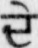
ਦੇ
